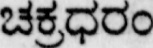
ಚಕ್ರಧರಂ
